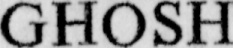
GHOSH
